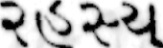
રહસ્ય
